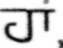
ਹਾਂ,
